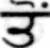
ਤੋਂ
